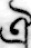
ঐ
